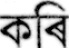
কৰি
